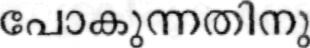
പോകുന്നതിനു
